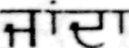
ਜਾਂਦਾ
